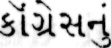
કૉંગ્રેસનું
